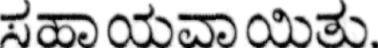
ಸಹಾಯವಾಯಿತು.
